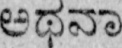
ಅಥವಾ
